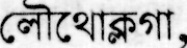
লৌথোক্লগা,
